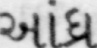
આંધ્ર
